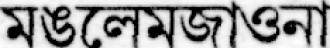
মঙলেমজাওনা
